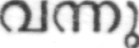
വന്നു
